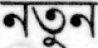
নতুন
